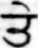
ਤੇ
